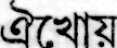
ঐখোয়
